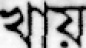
খায়
